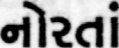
નોરતાં
